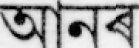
আনৰ
